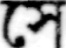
সে
